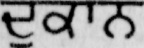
ਦੁਕਾਨ
